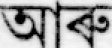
আৰু
